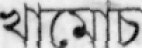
খামোচ
